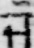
ਜੋ
